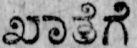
ಖಾತೆಗೆ
